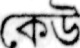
কেউ
